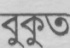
বুকুত
